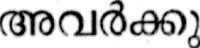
അവര്‍ക്കു
